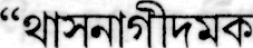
“থাসনাগীদমক
